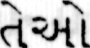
તેઓ
